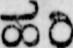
ಹರಿ
